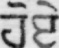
ਹੋਏ
